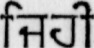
ਜਿਹੀ
